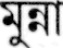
মুন্না
